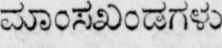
ಮಾಂಸಖಂಡಗಳು
